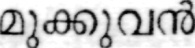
മുക്കുവന്‍
